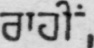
ਰਾਹੀਂ,
